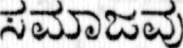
ಸಮಾಜವು
